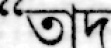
“তাদ
